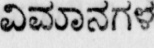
ವಿಮಾನಗಳ
